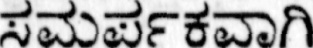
ಸಮರ್ಪಕವಾಗಿ
